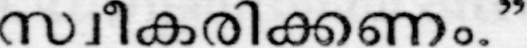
സ്വീകരിക്കണം."
